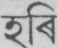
হৰি
